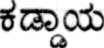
ಕಡ್ಡಾಯ
